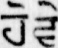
ਹੋਵੇ
